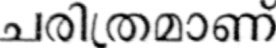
ചരിത്രമാണ്
